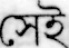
সেই
